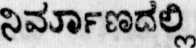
ನಿರ್ಮಾಣದಲ್ಲಿ
